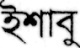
ইশাবু
